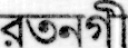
রতনগী
